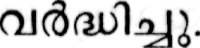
വര്‍ദ്ധിച്ചു.
